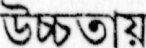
উচ্চতায়
